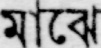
মাঝে
